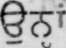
ਉਨ੍ਹਾਂ
